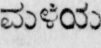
ಮಳೆಯ
